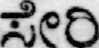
ಸೇರಿ
